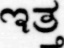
ಇತ್ತ
